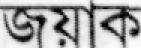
জয়াক
